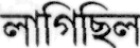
লাগিছিল
